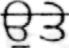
ਉਤੇ
